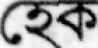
হেক
